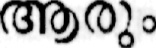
ആരും
